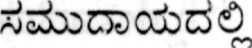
ಸಮುದಾಯದಲ್ಲಿ
